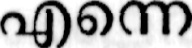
എന്നെ
